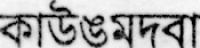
কাউঙমদবা
